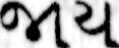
જાય
